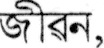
জীৱন,
